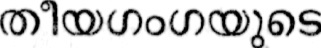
തീയഗംഗയുടെ
